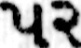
પર
